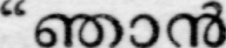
"ഞാന്‍
